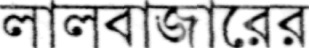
লালাবাজারের
